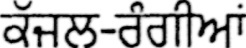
ਕੱਜਲ-ਰੰਗੀਆਂ
